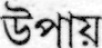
উপায়
